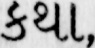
કથા,
